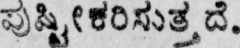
ಪುಷ್ಟೀಕರಿಸುತ್ತದೆ.
